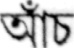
আঁচ
